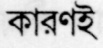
কারণই
